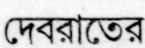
দেবরাতের
